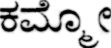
ಕಮ್ಮೋ
